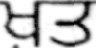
ਖ਼ਤ
